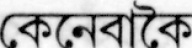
কেনেবাকৈ
